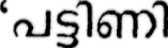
‘പട്ടിണി
